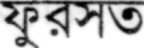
ফুরসত
